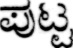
ಪುಟ್ಟ
